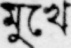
মুখে
